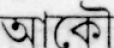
আকৌ
